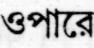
ওপারে
